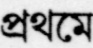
প্রথমে
